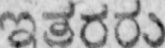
ಇತರರು
